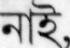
নাই,
